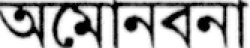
অমোনবনা
